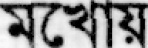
মখোয়
